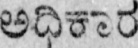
ಅಧಿಕಾರ
